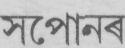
সপোনৰ
